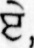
ਏ,
